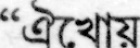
“ঐখোয়
